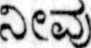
ನೀವು
